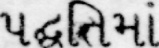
પદ્ધતિમાં
